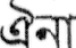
ঐনা
